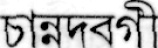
চান্নদবগী
